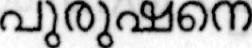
പുരുഷനെ
